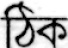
ঠিক
